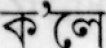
ক'লে
